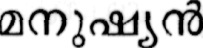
മനുഷ്യന്‍
